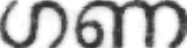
ഗണ
